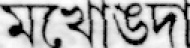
মখোঙদা
